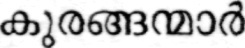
കുരങ്ങന്മാര്‍
